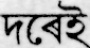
দৰেই
